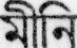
মীনি
